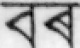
বৰ
